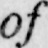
of
